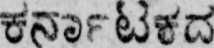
ಕರ್ನಾಟಕದ
